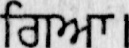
ਗਿਆ।
